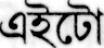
এইটো
